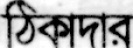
ঠিকাদার
